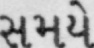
સમયે
